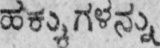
ಹಕ್ಕುಗಳನ್ನು
